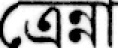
ত্রেন্না
